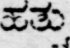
ಹತ್ತು
